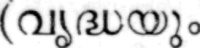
(വൃദ്ധയും
